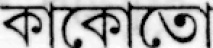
কাকোতো
